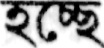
হচ্ছে
